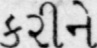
કરીને
